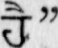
ਹੈ''
